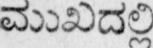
ಮುಖದಲ್ಲಿ
